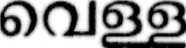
വെള്ള
